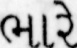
ભારે
